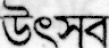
উৎসব
